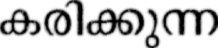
കരിക്കുന്ന
